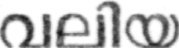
വലിയ
